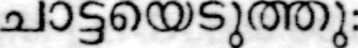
ചാട്ടയെടുത്തു:
